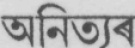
অনিত্যৰ
